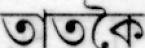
তাতকৈ
